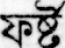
ফর্ষ্ট
